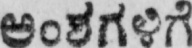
ಅಂಶಗಳಿಗೆ
